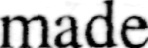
made
